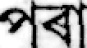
পৰা
